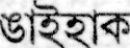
ঙাইহাক
